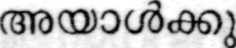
അയാള്‍ക്കു
